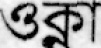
ওক্না
